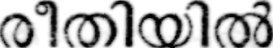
രീതിയില്‍
